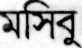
মসিবু
